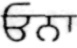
ਓਨਾ
